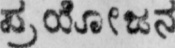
ಪ್ರಯೋಜನ
